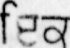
ਇਕ
